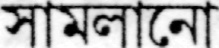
সামলানো
